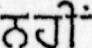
ਨਹੀਂ
